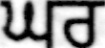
ਘਰ
